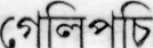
গেলিপচি
